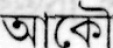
আকৌ
